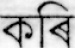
কৰি
